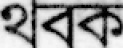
থবক
